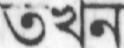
তখন
